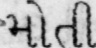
મોતી
